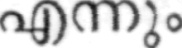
എന്നും
